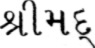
શ્રીમદ્
